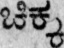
ಚಿಕ್ಕ
